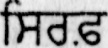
ਸਿਰਫ਼
